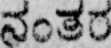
ನಂತರ
